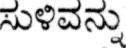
ಸುಳಿವನ್ನು
